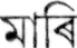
মাৰি
